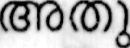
അതു
